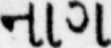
નાગ
